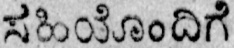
ಸಹಿಯೊಂದಿಗೆ
